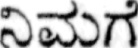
ನಿಮಗೆ
